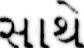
સાથે
